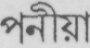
পনীয়া
